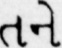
તને
